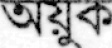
অয়ুক
